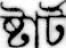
ষ্টার্ট
